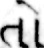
તો
